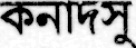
কনাদসু
